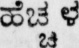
ಹೆಚ್ಚಳ
